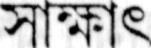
সাক্ষাৎ
